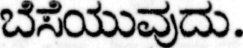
ಬೆಸೆಯುವುದು.
